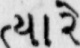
ત્યારે
